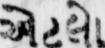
એટલે
